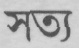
সত্য
